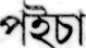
পইচা
